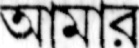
আমার
